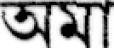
অমা
